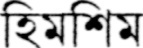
হিমশিম
